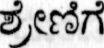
ಶ್ರೇಣಿಗೆ
